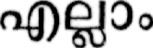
എല്ലാം
